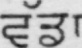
ਵੱਡਾ
